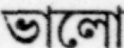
ভালো
